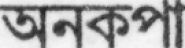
অনকপা
